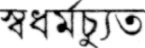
স্বধর্মচ্যুত
